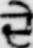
ਦੇ
